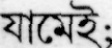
যামেই;
